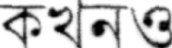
কখনও
